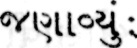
જણાવ્યું:
